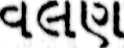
વલણ
